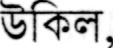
উকিল,
